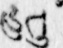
હતું
